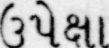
ઉપેક્ષા
